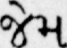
જેમ
